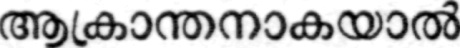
ആക്രാന്തനാകയാല്‍
